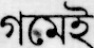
গমেই
